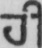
ਹੀ
